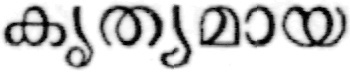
കൃത്യമായ
